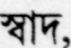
স্বাদ,
